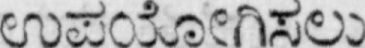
ಉಪಯೋಗಿಸಲು
